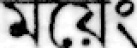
ময়েং
